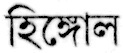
হিঙ্গোল
